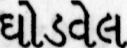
ઘોડવેલ
